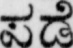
ಪಡೆ
